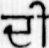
ਦੀ
